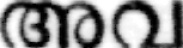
അവ
